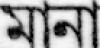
মানা
